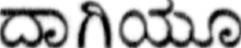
ದಾಗಿಯೂ
